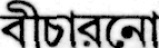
বীচারনো
